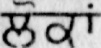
ਲੋਕਾਂ
